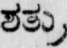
ಶತ್ರು
